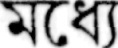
মধ্যে
